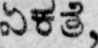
ಏಕತೆ,
